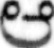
ಆ
